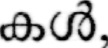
കള്‍,
